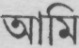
আমি
